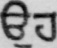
ਉਹ
